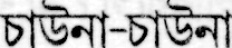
চাউনা-চাউনা
